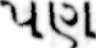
પણ
